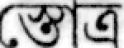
স্তোত্র
